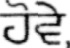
ਹੋਵੇ,
